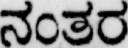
ನಂತರ
